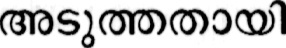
അടുത്തതായി
